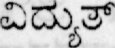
ವಿದ್ಯುತ್
